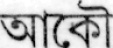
আকৌ
